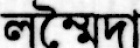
লম্মৈদা
